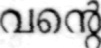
വന്റെ
